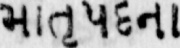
માતૃપદના
